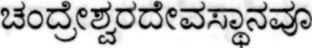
ಚಂದ್ರೇಶ್ವರದೇವಸ್ಥಾನವೂ
